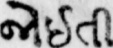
જોઈતી
